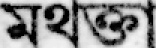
মথক্তা
